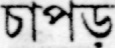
চাপড়
